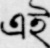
এই
